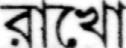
রাখো
